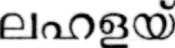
ലഹളയ്
